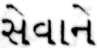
સેવાને
